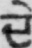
ਦੇ
